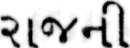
રાજની
